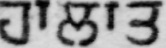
ਹਾਲਾਤ
